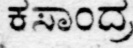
ಕಸಾಂದ್ರ
